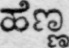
ಹೆಣ್ಣ
